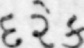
દરેક
